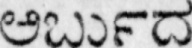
ಅರ್ಬುದ
